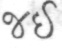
જઈ
